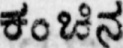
ಕಂಚಿನ
